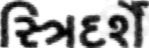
સ્ત્રિદર્શે
